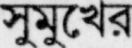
সুমুখের
